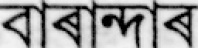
বাৰান্দাৰ
